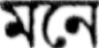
মনে
